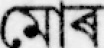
মোৰ
